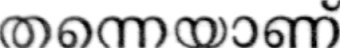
തന്നെയാണ്
